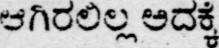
ಆಗಿರಲಿಲ್ಲಅದಕ್ಕೆ
